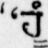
''ਹੂੰ
